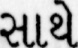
સાથે
